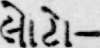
લોટો-
